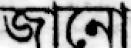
জানো
